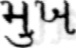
મુખ
